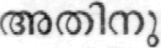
അതിനു
